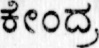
ಕೇಂದ್ರ
